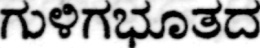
ಗುಳಿಗಭೂತದ
